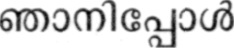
ഞാനിപ്പോള്‍
